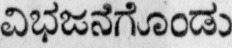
ವಿಭಜನೆಗೊಂಡು
